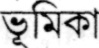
ভূমিকা
